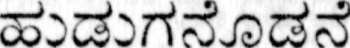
ಹುಡುಗನೊಡನೆ
